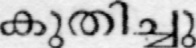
കുതിച്ചു
